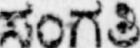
ಸಂಗತಿ
